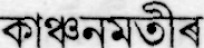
কাঞ্চনমতীৰ
